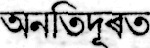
অনতিদূৰত
